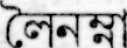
লৈনম্না
